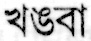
খঙবা
